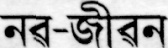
নৱ-জীৱন
